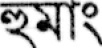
হুমাং
